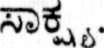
ಸಾಕ್ಷ್ಯ.
